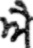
ਐ
